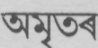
অমৃতৰ
